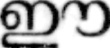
ഈ
